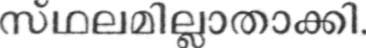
സ്ഥലമില്ലാതാക്കി.
